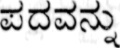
ಪದವನ್ನು
